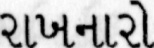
રાખનારો
